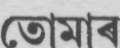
তোমাৰ
